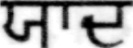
ਯਾਦ
